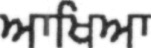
ਆਖਿਆ
